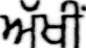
ਅੱਖੀਂ
